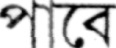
পাবে
